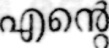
എന്റെ
